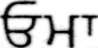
ਓਮਾ
